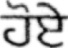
ਹੋਏ
